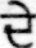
ਦੇ
